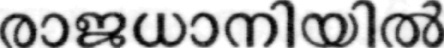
രാജധാനിയില്‍
